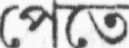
পেতে
